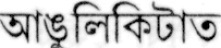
আঙুলিকিটাত
